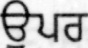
ਉਪਰ
